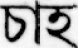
চাহ
